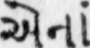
એનાં
